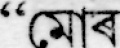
"মোৰ
